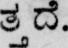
ತ್ತದೆ.
